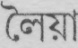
লৈয়া
